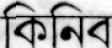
কিনিব
